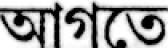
আগতে
